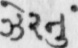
ઝેરનું
